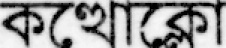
কত্থোক্লো
